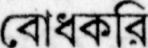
বোধকরি
